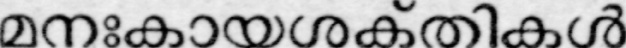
മനഃകായശക്തികള്‍
